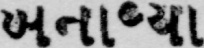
બનાવ્યા
